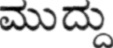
ಮುದ್ದು
